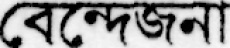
বেন্দেজনা
